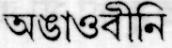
অঙাওবীনি
